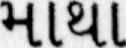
માથા
